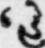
'હે
